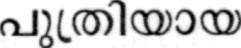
പുത്രിയായ
